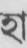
হা
